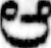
ಆ
